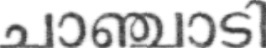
ചാഞ്ചാടി
